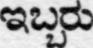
ಇಬ್ಬರು
